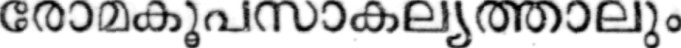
രോമകൂപസാകല്യത്താലും
